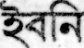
ইবনি
